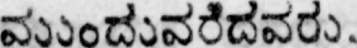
ಮುಂದುವರೆದರು.
